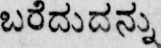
ಬರೆದುದನ್ನು
